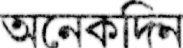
অনেকদিন
